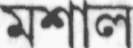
মশাল
